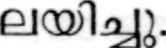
ലയിച്ചു.
